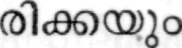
രിക്കയും
